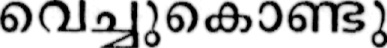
വെച്ചുകൊണ്ടു
